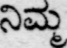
ನಿಮ್ಮ
